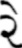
રે
